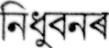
নিধুবনৰ
